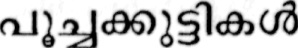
പൂച്ചക്കുട്ടികള്‍
